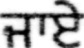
ਜਾਏ
